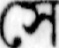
সে
